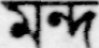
মন্দ
